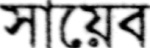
সায়েব
